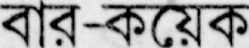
বার-কয়েক
